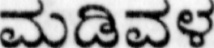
ಮಡಿವಳ
